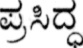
ಪ್ರಸಿದ್ಧ
